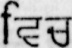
ਵਿਚ
